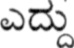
ಎದ್ದು
